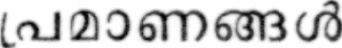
പ്രമാണങ്ങള്‍
